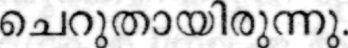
ചെറുതായിരുന്നു.
